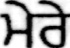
ਮੇਰੇ
